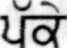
ਪੱਕੇ
